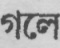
গলে
